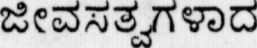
ಜೀವಸತ್ವಗಳಾದ
